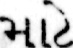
માટે
